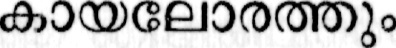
കായലോരത്തും
